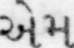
એમ
